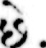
છે.
